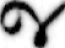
જ
